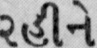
રહીને
